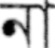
না
